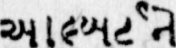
આલ્બર્ટને
